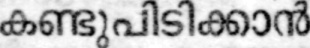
കണ്ടുപിടിക്കാന്‍
